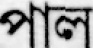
পাল
